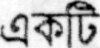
একটি
